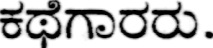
ಕಥೆಗಾರರು.
